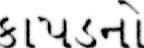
કાપડનો
